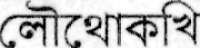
লৌথোকখি
